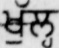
ਖੁੱਲ੍ਹ
